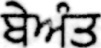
ਬੇਅੰਤ
